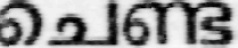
ചെണ്ട
